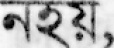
নহয়,
